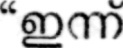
“ഇന്ന്
